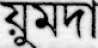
য়ুমদা
